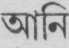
আনি
